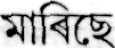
মাৰিছে
